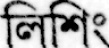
লিশিং
